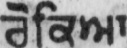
ਰੋਕਿਆ
